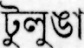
টুলুঙা
